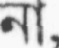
না,
